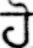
ਹੋ
